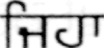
ਜਿਹਾ
